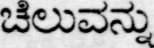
ಚೆಲುವನ್ನು
